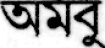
অমবু
